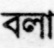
বলা
